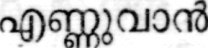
എണ്ണുവാന്‍
